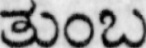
ತುಂಬ
